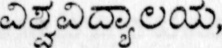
ವಿಶ್ವವಿದ್ಯಾಲಯ,
